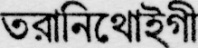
তরানিথোইগী
